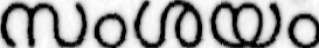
സംശയം
